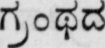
ಗ್ರಂಥದ
